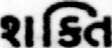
શક્તિ
